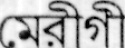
মেরীগী
